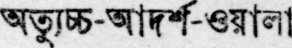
অত্যুচ্চ-আদর্শ-ওয়ালা
